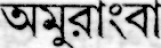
অমুরাংবা
